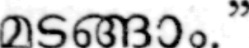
മടങ്ങാം."
